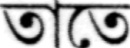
তাতে
